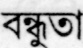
বন্ধুতা
